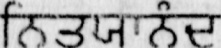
ਨਿਤਯਾਨੰਦ
